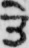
ਤੇ
